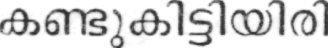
കണ്ടുകിട്ടിയിരി
